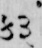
કરૂં
